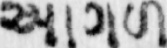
આગળ
